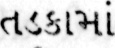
તડકામાં
